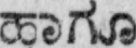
ಹಾಗೂ
